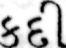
કદી
